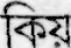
কিয়
